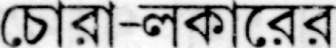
চোরা-লকারের
